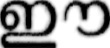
ഈ
